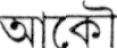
আকৌ
